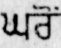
ਘਰੋਂ
